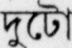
দুটো
